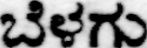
ಬೆಳಗು
